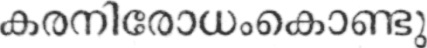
കരനിരോധംകൊണ്ടു
